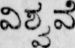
ವಿಶ್ವವೆ
